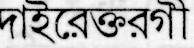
দাইরেক্তরগী
